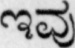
ಇವು
